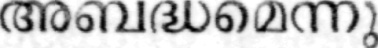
അബദ്ധമെന്നു
